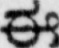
ಈ
